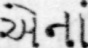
એનાં
